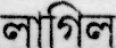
লাগিল
